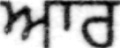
ਆਰ
